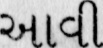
આવી
